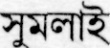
সুমলাই
